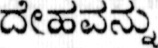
ದೇಹವನ್ನು
